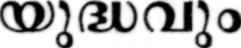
യുദ്ധവും
